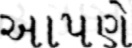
આપણે
